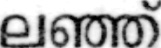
ലഞ്ഞ്
